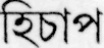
হিচাপ
